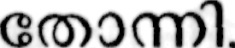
തോന്നി.
